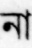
না
